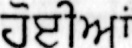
ਹੋਈਆਂ
